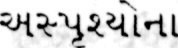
અસ્પૃશ્યોના
